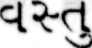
વસ્તુ
